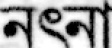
নৎনা
